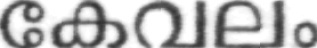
കേവലം
